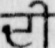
ਦੀ
